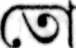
তো
